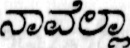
ನಾವೆಲ್ಲಾ
